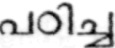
പഠിച്ച
